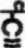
ਨੂੰ
